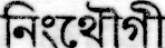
নিংথৌগী
